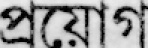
প্রয়োগ
